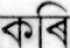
কৰি
